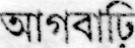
আগবাঢ়ি
